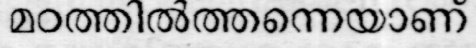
മഠത്തില്‍ത്തന്നെയാണ്
